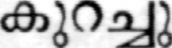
കുറച്ചു
